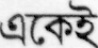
একেই
